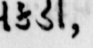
પકડી,
